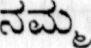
ನಮ್ಮ
